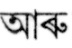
আৰু
